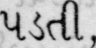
પડતી,
